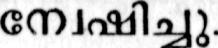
ന്വേഷിച്ചു.
